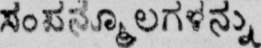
ಸಂಪನ್ಮೂಲಗಳನ್ನು
